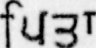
ਪਿਤਾ
